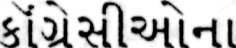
કૉંગ્રેસીઓના
